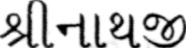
શ્રીનાથજી
